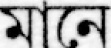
মানে
